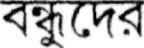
বন্ধুদের
